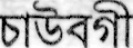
চাউবগী
